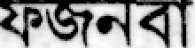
ফজনবা
